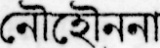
নৌহৌননা
